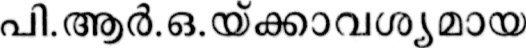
പി.ആര്‍.ഒ.യ്ക്കാവശ്യമായ
